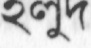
হলুদ
